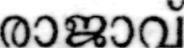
രാജാവ്
